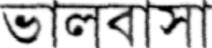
ভালবাসা
